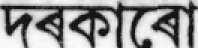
দৰকাৰো
